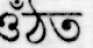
ওঁঠত
